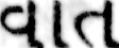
વાત
